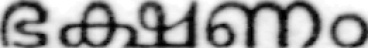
ഭക്ഷണം
